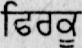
ਫਿਰਕੂ
